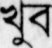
খুব
